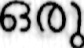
ഒരു
